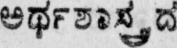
ಅರ್ಥಶಾಸ್ತ್ರದ
